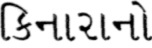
કિનારાનો
